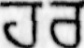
ਹਰ
